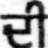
ਦੀ
